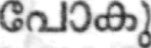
പോകു
